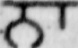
ਨਾ
